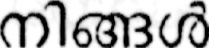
നിങ്ങള്‍
